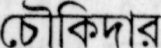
চৌকিদার
